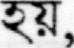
হয়,
